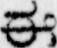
ಈ
